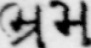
ભ્રમ
